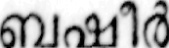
ബഷീര്‍
